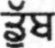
ਡੁੱਬ
